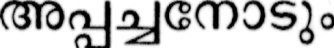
അപ്പച്ചനോടും
